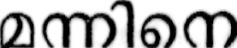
മന്നിനെ
